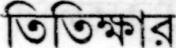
তিতিক্ষার
